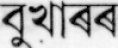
বুখাৰৰ
